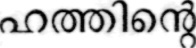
ഹത്തിന്റെ
